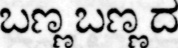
ಬಣ್ಣಬಣ್ಣದ
